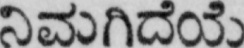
ನಿಮಗಿದೆಯೆ
